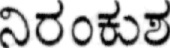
ನಿರಂಕುಶ
